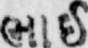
ભાઈ
